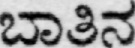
ಬಾತಿನ
